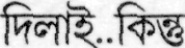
দিলাই..কিন্তু
